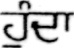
ਹੁੰਦਾ
